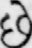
છે
